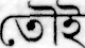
তৌই
